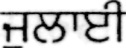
ਜੁਲਾਈ
